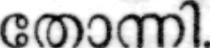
തോന്നി.
